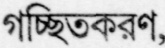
গচ্ছিতকরণ,
